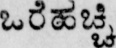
ಒರೆಹಚ್ಚಿ
